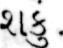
શકું.
